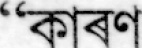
"কাৰণ
